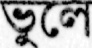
ভুলে
